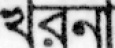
খরনা
